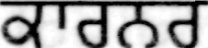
ਕਾਰਨਰ
